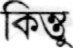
কিন্তু
